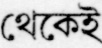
থেকেই
